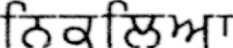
ਨਿਕਲਿਆ
